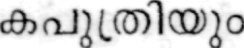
കപുത്രിയും
